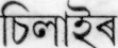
চিলাইৰ
